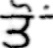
ਤੋਂ
